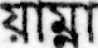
য়াম্না
